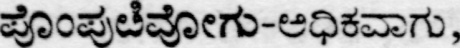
ಪೊ೦ಪುೞೆವೋಗು-ಅಧಿಕವಾಗು,
